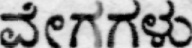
ವೇಗಗಳು
